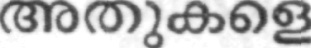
അതുകളെ
